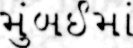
મુંબઈમાં
